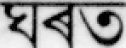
ঘৰত
